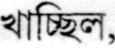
খাচ্ছিল,
